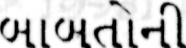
બાબતોની
